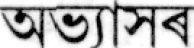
অভ্যাসৰ
